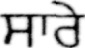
ਸਾਰੇ
